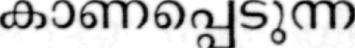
കാണപ്പെടുന്ന
